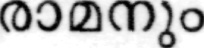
രാമനും
